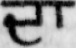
ਦਾ
